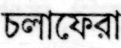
চলাফেরা
